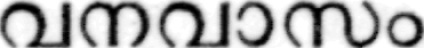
വനവാസം
